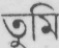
তুমি
